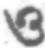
ও
